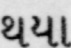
થયા
